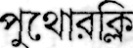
পুথোরক্লি
